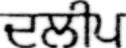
ਦਲੀਪ
